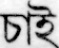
চাই
